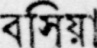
বসিয়া
